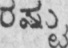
ರಷ್ಟು
